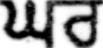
ਘਰ
